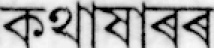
কথাষাৰৰ
